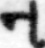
ન
